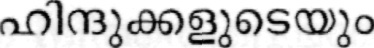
ഹിന്ദുക്കളുടെയും
